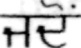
ਜਦੋਂ
